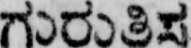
ಗುರುತಿಸ
